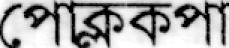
পোক্লকপা
